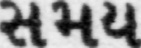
સમય
